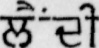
ਲੈਂਦੀ
